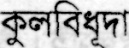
কুলবিধূদা
